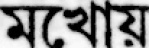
মখোয়
